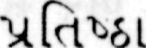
પ્રતિષ્ઠા
